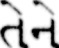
તેને
